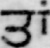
ਤਾਂ
